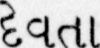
દેવતા
